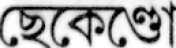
ছেকেণ্ডো
